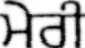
ਮੇਰੀ
